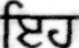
ਇਹ
